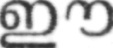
ഈ
